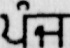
ਪੰਜ
